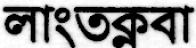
লাংতক্নবা
